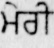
ਮੇਰੀ
